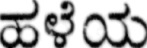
ಹಳೆಯ
